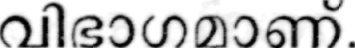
വിഭാഗമാണ്.
